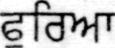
ਫੁਰਿਆ
